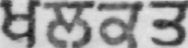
ਖਲਕਤ
